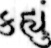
કહ્યું
